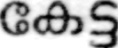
കേട്ട
